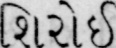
શિરોઈ
